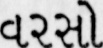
વરસો
